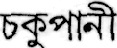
চকুপানী
